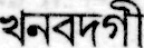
খনবদগী
